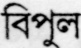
বিপুল
